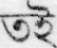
তই
